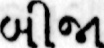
બીજા
